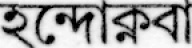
হন্দোক্নবা
